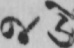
જડે
